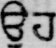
ਉਹ
